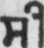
ਸੀ
